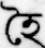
হৈ
